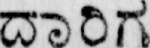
ದಾರಿಗ
